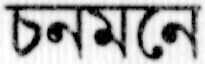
চনমনে
